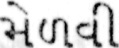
મેળવી
